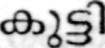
കുട്ടി
